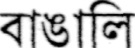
বাঙালি
